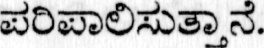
ಪರಿಪಾಲಿಸುತ್ತಾನೆ.
